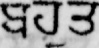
ਬਹੁਤ
